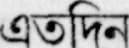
এতদিন
